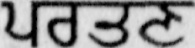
ਪਰਤਣ
